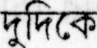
দুদিকে
